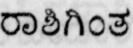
ರಾಶಿಗಿಂತ
